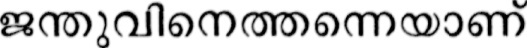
ജന്തുവിനെത്തന്നെയാണ്
